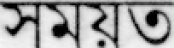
সময়ত
